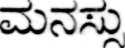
ಮನಸ್ಸು
